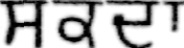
ਸਕਦਾ
